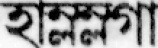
হাম্লম্লগা
